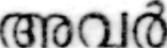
അവര്‍
